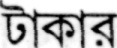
টাকার
